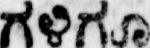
ಗಳಿಗೂ
